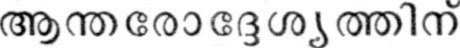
ആന്തരോദ്ദേശ്യത്തിന്
